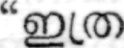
“ഇത്ര
